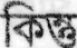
কিন্তু
